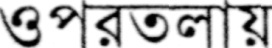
ওপরতলায়
